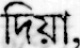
দিয়া,
